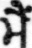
ਮੈਂ
